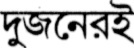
দুজনেরই
